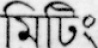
মিটিং
